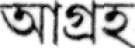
আগ্রহ
